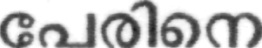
പേരിനെ
